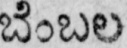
ಬೆಂಬಲ
